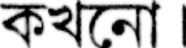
কখনো।
